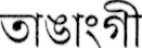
তাঙাংগী
